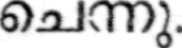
ചെന്നു.
